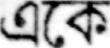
একে
